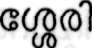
ശ്ശേരി
